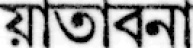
য়াতাবনা
